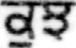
ਕੁਝ
